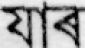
যাৰ
